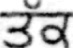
ਤੱਕ
